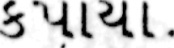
કપાયા.
